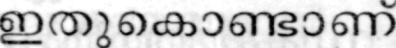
ഇതുകൊണ്ടാണ്
